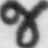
જ
